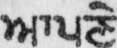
ਆਪਣੇ
